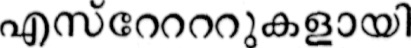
എസ്റേറററുകളായി
